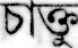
চাক্তু
